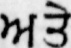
ਅਤੇ
